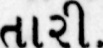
તારી.
